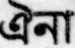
ঐনা
